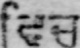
ਵਿਚ
